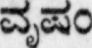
ವೃಷಂ
